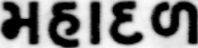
મહાદળ
